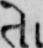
તો
